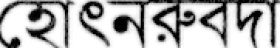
হোৎনরুবদা
